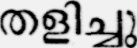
തളിച്ചു
